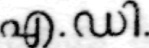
എ.ഡി.
